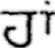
ਹਾਂ
